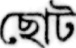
ছোট
